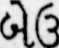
બેઉ
